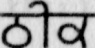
ਠੀਕ
